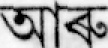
আৰু
